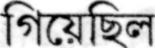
গিয়েছিল
